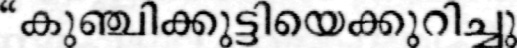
“കുഞ്ചിക്കുട്ടിയെക്കുറിച്ചു
